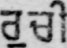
ਰੁਚੀ
